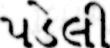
પડેલી
